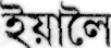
ইয়ালৈ
